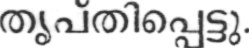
തൃപ്തിപ്പെട്ടു.
